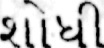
શોધી
